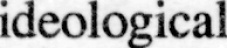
ideological
